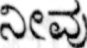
ನೀವು
